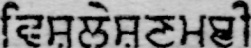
ਵਿਸ਼ਲੇਸ਼ਣਮਈ
